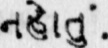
નહોતું.
